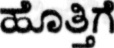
ಹೊತ್ತಿಗೆ
